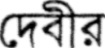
দেবীর
